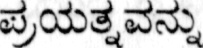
ಪ್ರಯತ್ನವನ್ನು
